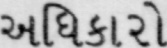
અધિકારો
